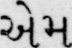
એમ
